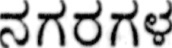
ನಗರಗಳ
